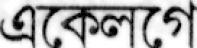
একেলগে
